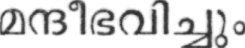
മന്ദീഭവിച്ചും
